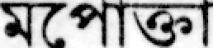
মপোক্তা
